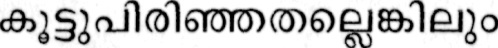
കൂട്ടുപിരിഞ്ഞതല്ലെങ്കിലും
